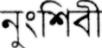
নুংশিবী
